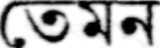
তেমন
